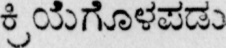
ಕ್ರಿಯೆಗೊಳಪಡು
